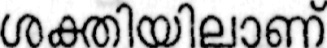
ശക്തിയിലാണ്
